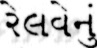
રેલવેનું
